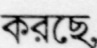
করছে,
